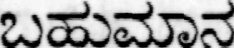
ಬಹುಮಾನ
